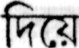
দিয়ে
